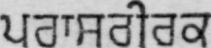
ਪਰਾਸਰੀਰਕ
